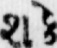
શકે
